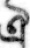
ঐ
